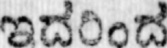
ಇದರಿಂದ
